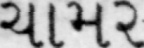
ચામર
